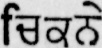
ਚਿਕਨੇ
